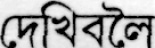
দেখিবলৈ
